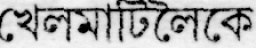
খেলমাটিলৈকে
